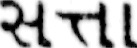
સત્તા
